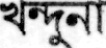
খন্দুনা
